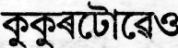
কুকুৰটোৱেও
